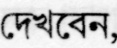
দেখবেন,
